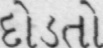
દોડતો
